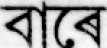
বাৰে
